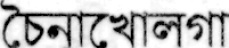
চৈনাথোলগা
